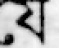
যে
